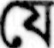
যে
